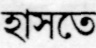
হাসতে
